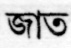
জাত
